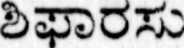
ಶಿಫಾರಸು
